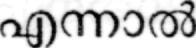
എന്നാല്‍
